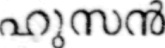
ഹുസന്‍
